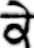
ਕੇ
